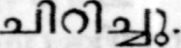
ചിറിച്ചു.
